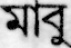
মাবু
